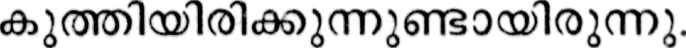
കുത്തിയിരിക്കുന്നുണ്ടായിരുന്നു.
